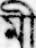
মী
